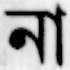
না
